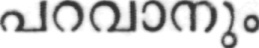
പറവാനും
